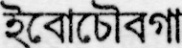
ইবোচৌবগা
